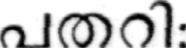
പതറി:
